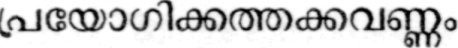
പ്രയോഗിക്കത്തക്കവണ്ണം
